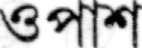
ওপাশ
